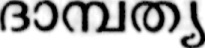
ദാമ്പത്യ
